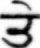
ਤੇ
